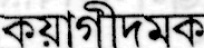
কয়াগীদমক
